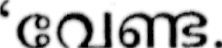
‘വേണ്ട.
